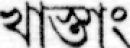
খাস্তাং
